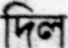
দিল
